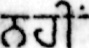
ਨਹੀਂ
